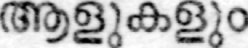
ആളുകളും
